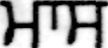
ਮਾਸ
